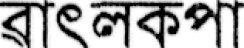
ৱাৎলকপা
